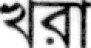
খরা
